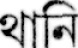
থানি
